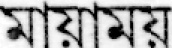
মায়াময়
